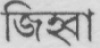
জিহ্বা
